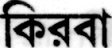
কিরবা
